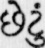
છેટું
